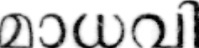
മാധവി
